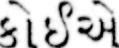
કોઇએ
